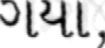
ગયા,
